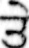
ਤੇ
